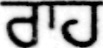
ਰਾਹ
